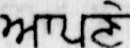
ਆਪਣੇ
